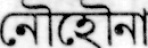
নৌহৌনা
